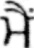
ਮੈਂ
